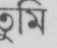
তুমি
